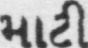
માટી
